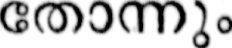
തോന്നും
